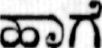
ಹಾಗೆ
